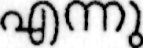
എന്നു
